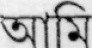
আমি
